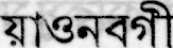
য়াওনবগী
